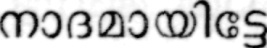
നാദമായിട്ടേ
